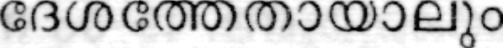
ദേശത്തേതായാലും
